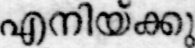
എനിയ്ക്കു
